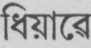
ধিয়াৱে
